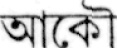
আকৌ
